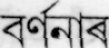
বর্ণনাৰ
